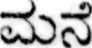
ಮನೆ
